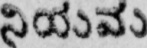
ನಿಯಮ
